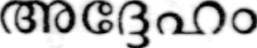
അദ്ദേഹം
